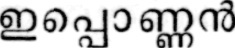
ഇപ്പൊണ്ണന്‍
